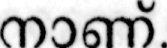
നാണ്.
